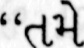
"તમે
